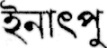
ইনাৎপু
